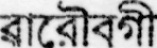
ৱারৌবগী
